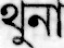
থুনা
